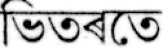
ভিতৰতে
